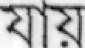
যায়
